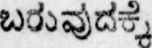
ಬರುವುದಕ್ಕೆ
